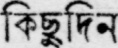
কিছুদিন
